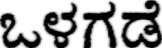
ಒಳಗಡೆ
